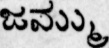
ಜಮ್ಮು
